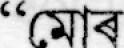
"মোৰ
